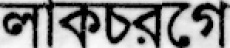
লাকচরগে
